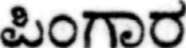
ಪಿಂಗಾರ
